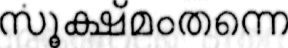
സൂക്ഷ്മംതന്നെ
